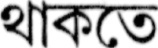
থাকতে
